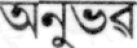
অনুভৱ
